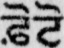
ਫ਼ੋਟੋ
